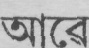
আৱে
